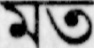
মত
